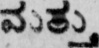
ಮತ್ತು
